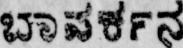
ಬಾವರ್ಕನ
